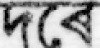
দৰে
